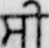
ਸੀ
